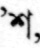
’শ,
